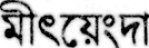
মীৎয়েংদা
